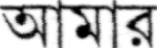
আমার
